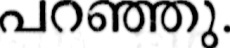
പറഞ്ഞു.
